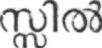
സ്സില്‍
